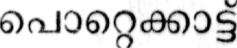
പൊറ്റെക്കാട്ട്
